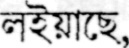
লইয়াছে,
